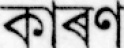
কাৰণ
